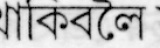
থাকিবলৈ
